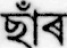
ছাঁৰ
